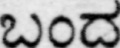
ಬಂದ
